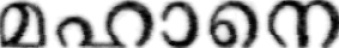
മഹാനെ
